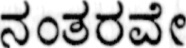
ನಂತರವೇ
